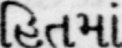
હિતમાં
